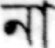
না
